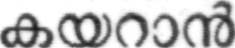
കയറാന്‍
